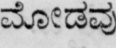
ಮೋಡವು
